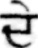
ਦੇ
